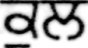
ਕੁਲ
